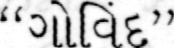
"ગોવિંદ"
